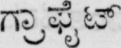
ಗ್ರಾಫೈಟ್
